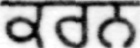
ਕਰਨ
